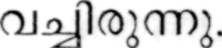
വച്ചിരുന്നു.
